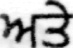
ਅਤੇ
